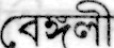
বেঙ্গলী
